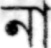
না
